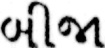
બીજા
